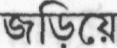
জড়িয়ে
